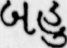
બહુ
